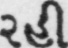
રહી
